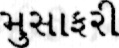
મુસાફરી
